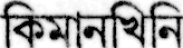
কিমানখিনি
